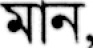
মান,
